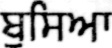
ਬੁਸਿਆ
